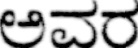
ಅವರ
